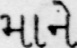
માને
